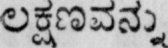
ಲಕ್ಷಣವನ್ನು
